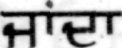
ਜਾਂਦਾ
